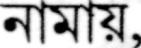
নামায়,
